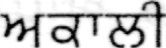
ਅਕਾਲੀ
